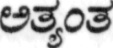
ಅತ್ಯಂತ
